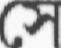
সে
